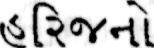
હરિજનો
